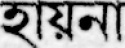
হায়না
